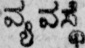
ವ್ಯವಸ್ಥೆ
